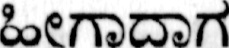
ಹೀಗಾದಾಗ
